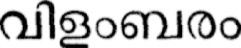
വിളംബരം
